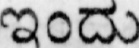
ಇಂದು
